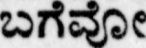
ಬಗೆವೋ
